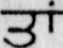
ਤਾਂ
